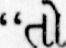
"તો
